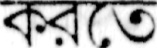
করতে
